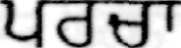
ਪਰਚਾ
